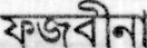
ফজবীনা
